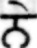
ਨੇ
